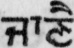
ਜਾਣੈ
